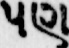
પણ
